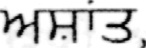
ਅਸ਼ਾਂਤ,
